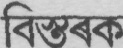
বিস্তৰক
